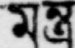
মন্ত্র
